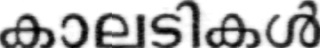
കാലടികള്‍
